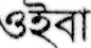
ওইবা
